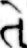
તે
